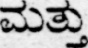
ಮತ್ತು
